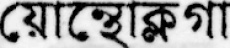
য়োন্থোক্লগা
